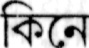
কিনে
